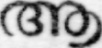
ആ
